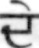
ਦੇ
